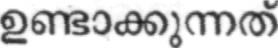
ഉണ്ടാക്കുന്നത്
